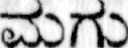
ಮಗು
